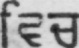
ਵਿਚ
